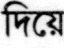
দিয়ে
